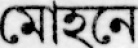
মোহনে
